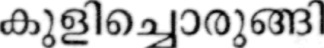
കുളിച്ചൊരുങ്ങി
